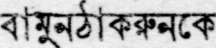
বামুনঠাকরুনকে
